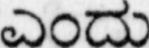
ಎಂದು
